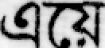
এয়ে
